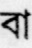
বা
